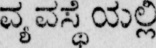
ವ್ಯವಸ್ಥೆಯಲ್ಲಿ
